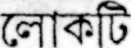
লোকটি
